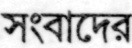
সংবাদের
